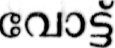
വോട്ട്
